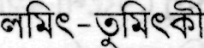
লমিৎ-তুমিৎকী
